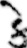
કે
